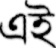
এই
